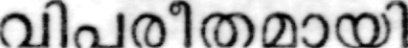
വിപരീതമായി
